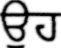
ਉਹ
